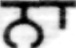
ਨਾ
